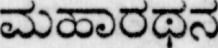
ಮಹಾರಥನ
